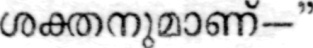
ശക്തനുമാണ്-”
